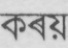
কৰয়
